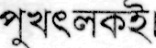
পুখৎলকই।
